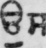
ਉਸ
